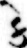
કે
